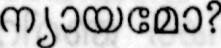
ന്യായമോ?
